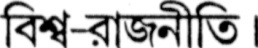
বিশ্ব-রাজনীতি।
